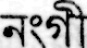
নংগী
